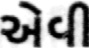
એવી
